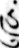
હું
